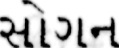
સોગન
